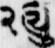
રહ્યું
